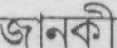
জানকী
